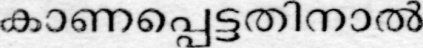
കാണപ്പെട്ടതിനാല്‍
